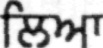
ਲਿਆ
